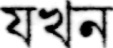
যখন
